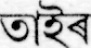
তাইৰ
